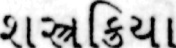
શસ્ત્રક્રિયા
